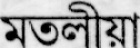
মতলীয়া
